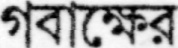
গবাক্ষের
